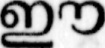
ഈ
